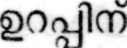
ഉറപ്പിന്
